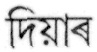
দিয়াৰ
